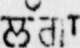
ਲੱਗਾ
